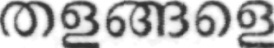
തളങ്ങളെ
